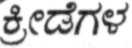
ಕ್ರೀಡೆಗಳ
